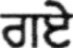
ਗਏ
